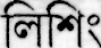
লিশিং
